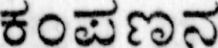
ಕಂಪಣನ
